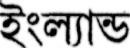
ইংল্যান্ড
